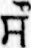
ਸੌ
